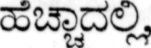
ಹೆಚ್ಚಾದಲ್ಲಿ,
